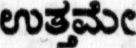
ಉತ್ತಮೇ
